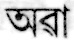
অৱা
